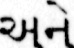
અને
